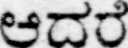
ಆದರೆ
